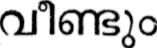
വീണ്ടും
